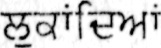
ਲੁਕਾਂਦਿਆਂ
